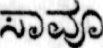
ಸಾವೂ
